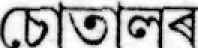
চোতালৰ
